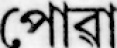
পোৱা
